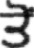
ਤੋਂ
